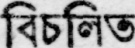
বিচলিত
